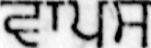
ਵਾਪਸ
